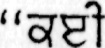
''ਕਈ
